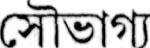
সৌভাগ্য
